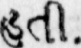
હતી.
